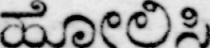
ಹೋಲಿಸಿ
